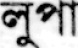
লুপা
